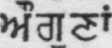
ਔਗੁਣਾਂ
